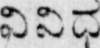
ವಿವಿಧ
